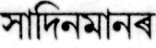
সাদিনমানৰ
